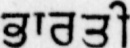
ਭਾਰਤੀ
